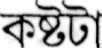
কষ্টটা
